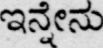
ಇನ್ನೇನು
